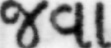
જવા
